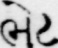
ભેટ
